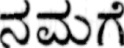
ನಮಗೆ
